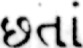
છતાં
